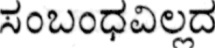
ಸಂಬಂಧವಿಲ್ಲದ
